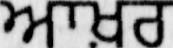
ਆਖ਼ਰ
